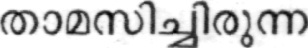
താമസിച്ചിരുന്ന
